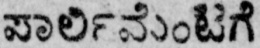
ಪಾರ್ಲಿಮೆಂಟಿಗೆ
